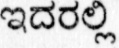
ಇದರಲ್ಲಿ
